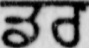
ਡਰ
